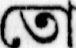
তো
